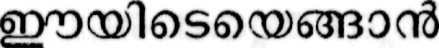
ഈയിടെയെങ്ങാന്‍
